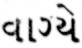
વાગ્યે
